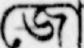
জো
